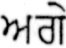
ਅਗੇ
